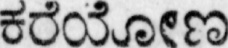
ಕರೆಯೋಣ
